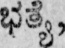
ಭತ್ಯೆ,
